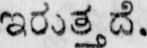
ಇರುತ್ತದೆ.
